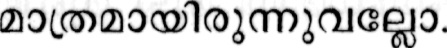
മാത്രമായിരുന്നുവല്ലോ.
